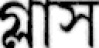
গ্লাস
